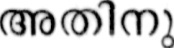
അതിനു
